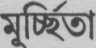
মুৰ্চ্ছিতা
